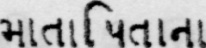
માતાપિતાના
